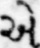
એ
